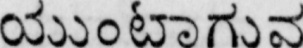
ಯುಂಟಾಗುವ
